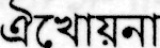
ঐখোয়না
